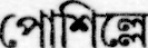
পোশিল্লে
